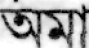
অমা
